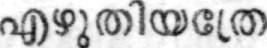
എഴുതിയത്രേ
